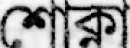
শোক্না
